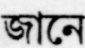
জানে
